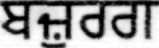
ਬਜ਼ੁਰਗ
